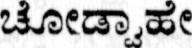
ಚೋಡ್ವಾಹೇ
